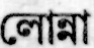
লোন্না
